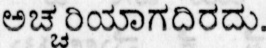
ಅಚ್ಚರಿಯಾಗದಿರದು.
